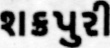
શકપુરી
